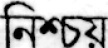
নিশ্চয়
